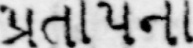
પ્રતાપના
